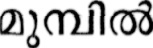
മുമ്പില്‍
